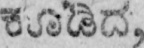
ಕೂಡಿದ,
